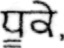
ਧੂਕੇ,
